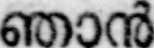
ഞാന്‍
